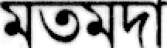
মতমদা
